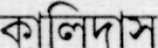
কালিদাস
